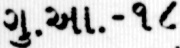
ગુ.આ.-૧૮
